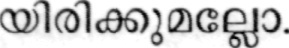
യിരിക്കുമല്ലോ.
